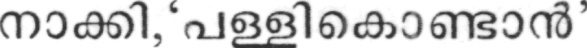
നാക്കി,'പള്ളികൊണ്ടാന്‍'
